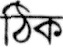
ঠিক
